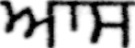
ਆਸ
